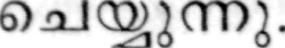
ചെയ്യുന്നു.
